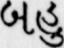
બહુ
